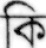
কি
